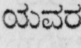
ಯವರ
